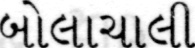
બોલાચાલી
